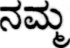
ನಮ್ಮ
